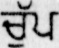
ਚੁੱਪ
